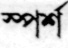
স্পর্শ
